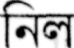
নিল
